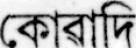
কোৱাদি
